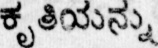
ಕೃತಿಯನ್ನು
